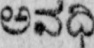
ಅವಧಿ
